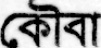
কৌবা
